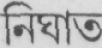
নিঘাত
